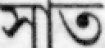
সাত
